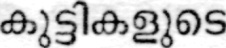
കുട്ടികളുടെ
